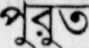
পুরুত
